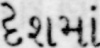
દેશમાં
